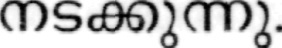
നടക്കുന്നു.
